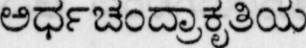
ಅರ್ಧಚಂದ್ರಾಕೃತಿಯ
